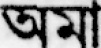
অমা
